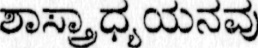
ಶಾಸ್ತ್ರಾಧ್ಯಯನವು
